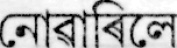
নোৱাৰিলে
